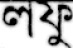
লফু
